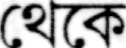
থেকে
